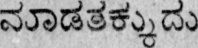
ಮಾಡತಕ್ಕುದು
